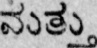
ಮತ್ತು
